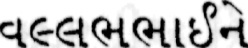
વલ્લભભાઈને
